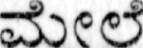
ಮೇಲೆ
